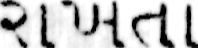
રાખતા
